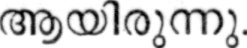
ആയിരുന്നു.
